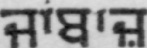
ਜਾਬਾਜ਼
